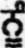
ਨੂੰ
